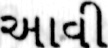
આવી
